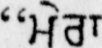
''ਮੇਰਾ
